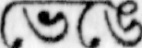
ভেঙে
